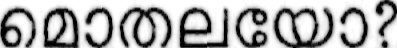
മൊതലയോ?
